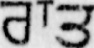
ਰਾਤ
